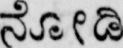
ನೋಡಿ
